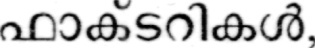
ഫാക്ടറികള്‍,
